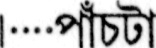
৷....পাঁচটা
